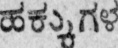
ಹಕ್ಕುಗಳ
